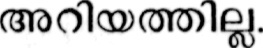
അറിയത്തില്ല.
